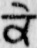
ਕੇ
